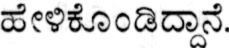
ಹೇಳಿಕೊಂಡಿದ್ದಾನೆ.
